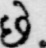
છે.
